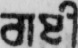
ਗਈ
